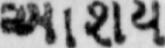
આશય
